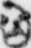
છે
